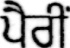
ਪੈਰੀਂ
